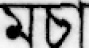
মচা
